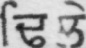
ਢਿਲੇ
